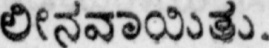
ಲೀನವಾಯಿತು.
